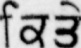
ਕਿਤੇ
